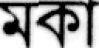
মকা
